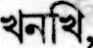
খনখি,
